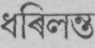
ধৰিলন্ত
